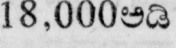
18,000ಅಡಿ
